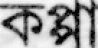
কপ্পা
